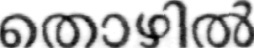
തൊഴില്‍
